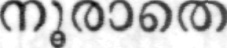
നൂരാതെ
